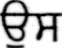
ਉਸ
